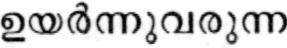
ഉയര്‍ന്നുവരുന്ന
